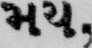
મય,
